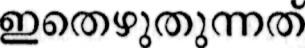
ഇതെഴുതുന്നത്
